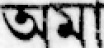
অমা
